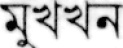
মুখখন
